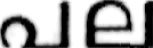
പല
